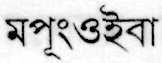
মপূংওইবা
